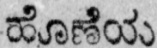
ಹೊಣೆಯ
